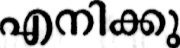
എനിക്കു
